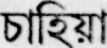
চাহিয়া
